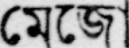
মেজো
